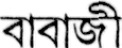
বাবাজী
